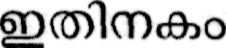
ഇതിനകം
